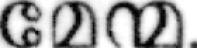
മേന്മ.
